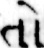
તો
